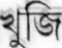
খুজি
